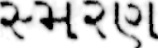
સ્મરણ
